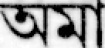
অমা
